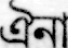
ঐনা
